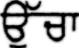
ਉੱਚਾ
